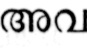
അവ
